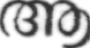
ആ
